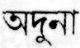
অদুনা
